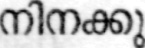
നിനക്കു
